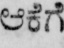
ಆಕೆಗೆ
